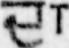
ਦਾ
